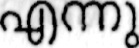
എന്നു
